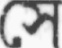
সে
